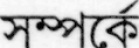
সম্পৰ্কে
